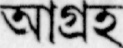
আগ্রহ
